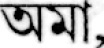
অমা,
